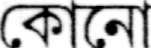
কোনো
